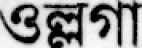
ওল্লগা
